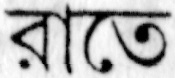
রাতে
